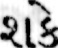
શકે
